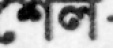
শেল
